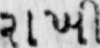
રાખી
